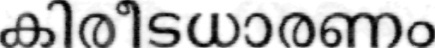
കിരീടധാരണം
